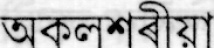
অকলশৰীয়া
